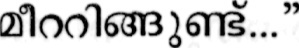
മീററിങ്ങുണ്ട്..."
